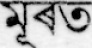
মূৰত
